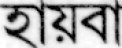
হায়বা
